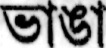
ভাঙা
